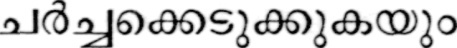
ചര്‍ച്ചക്കെടുക്കുകയും
